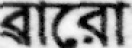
ৱারো
